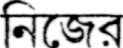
নিজের
